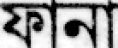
ফানা
